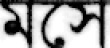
মসে
